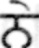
ਨੇ
